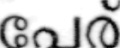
പേര്
